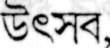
উৎসব,
